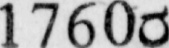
1760ರ
